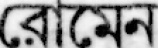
রোমেন
